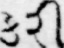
કરી
